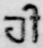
ਹੀ
